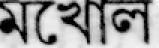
মখোল
